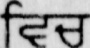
ਵਿਚ
